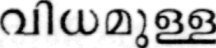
വിധമുള്ള
